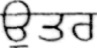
ਉਤਰ
